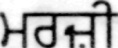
ਮਰਜ਼ੀ
